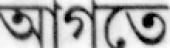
আগতে
